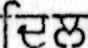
ਦਿਲ
